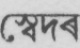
স্বেদৰ
